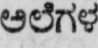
ಅಲೆಗಳ
